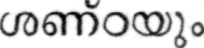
ശണ്ഠയും
